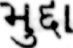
મુદ્દા
